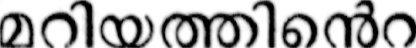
മറിയത്തിന്റെ
